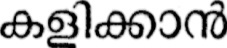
കളിക്കാന്‍
